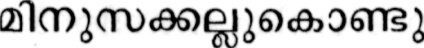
മിനുസക്കല്ലുകൊണ്ടു
